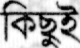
কিছুই
